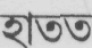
হাতত
